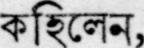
কহিলেন,
